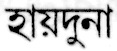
হায়দুনা
